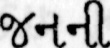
જનની
